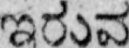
ಇರುವ
